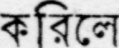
করিলে
